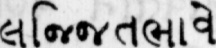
લજ્જિતભાવે
